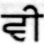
ਵੀ
